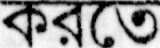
করতে
